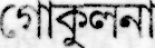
গোকুলনা
